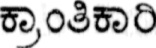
ಕ್ರಾಂತಿಕಾರಿ
